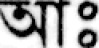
আঃ
